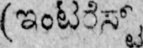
(ಇಂಟರೆಸ್ಟ್
